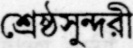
শ্রেষ্ঠসুন্দরী
